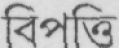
বিপত্তি
